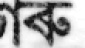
গৰু
